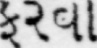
ફરવા
